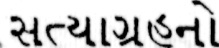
સત્યાગ્રહનો
